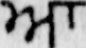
ਆ
